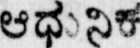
ಆಧುನಿಕ
